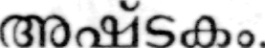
അഷ്ടകം.
